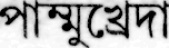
পাম্মুখ্রেদা
